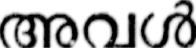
അവള്‍
